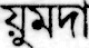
য়ুমদা
